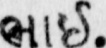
ભાઈ.
